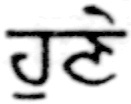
ਹੁਣੇ
